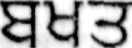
ਬਖਤ
